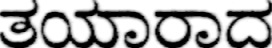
ತಯಾರಾದ
